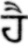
ਹੈ
